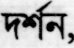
দর্শন,
